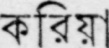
করিয়া
